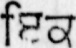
ਇਕ
